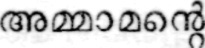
അമ്മാമന്റെ
